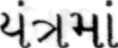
યંત્રમાં
